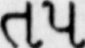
તપ
